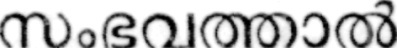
സംഭവത്താല്‍
